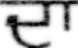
ਦਾ
